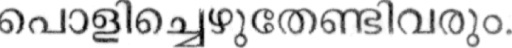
പൊളിച്ചെഴുതേണ്ടിവരും.
